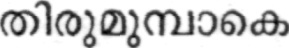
തിരുമുമ്പാകെ
